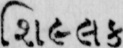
શિલ્લક
